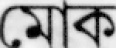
মোক
